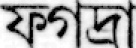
ফগদ্রা
